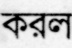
করল
